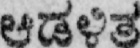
ಆಡಳಿತ
